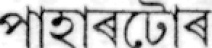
পাহাৰটোৰ
